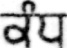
ਕੰਧ
